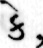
કે,
